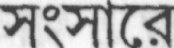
সংসারে
